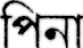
পিনা
